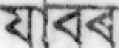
যাবৰ
